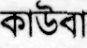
কাউবা
